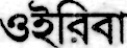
ওইরিবা
